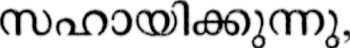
സഹായിക്കുന്നു,
